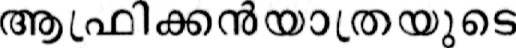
ആഫ്രിക്കന്‍യാത്രയുടെ
